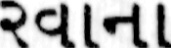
રવાના
